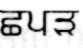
ਛਪੜ
